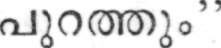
പുറത്തും"
